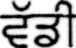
ਵੱਡੀ
